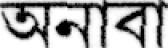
অনাবা
